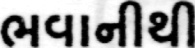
ભવાનીથી
